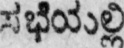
ಸಭೆಯಲ್ಲಿ
